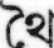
থৈ
